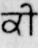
ਕੀ
